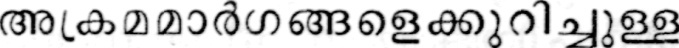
അക്രമമാര്‍ഗങ്ങളെക്കുറിച്ചുള്ള
